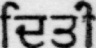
ਦਿਤੀ
